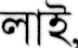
লাই,
